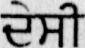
ਦੇਸੀ
